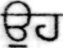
ਉਹ
